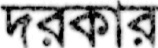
দরকার
